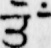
ਤੋਂ
